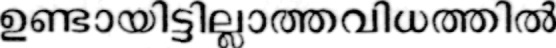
ഉണ്ടായിട്ടില്ലാത്തവിധത്തില്‍
